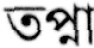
তপ্না
